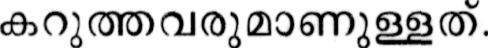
കറുത്തവരുമാണുള്ളത്.
